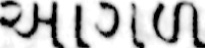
આગળ
